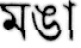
মঙা
